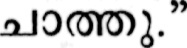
ചാത്തു.”
